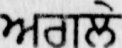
ਅਗਲੇ
